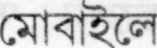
মোবাইলে
